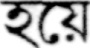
হয়ে
